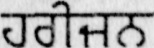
ਹਰੀਜਨ
